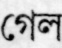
গেল
